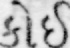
કોઈ
